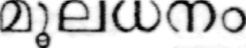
മൂലധനം
